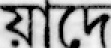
য়াদে
